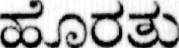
ಹೊರತು
